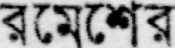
রমেশের
